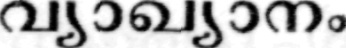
വ്യാഖ്യാനം
